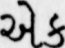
એક
